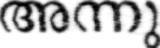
അന്നു
